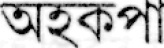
অহকপা
